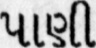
પાણી
